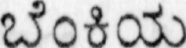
ಬೆಂಕಿಯ
